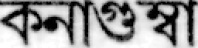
কনাগুম্বা
